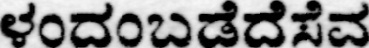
ಳಂದಂಬಡೆದೆಸೆವ
